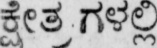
ಕ್ಷೇತ್ರಗಳಲ್ಲಿ
